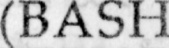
(BASH
